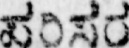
ಪರಿಸರ
